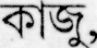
কাজু,
